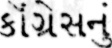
કૉંગ્રેસનું
